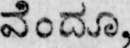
ವೆಂದೂ,
